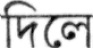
দিলে
